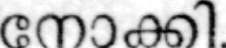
നോക്കി.
